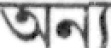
অন্য
